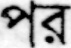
পর
